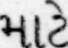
માટે
